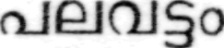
പലവട്ടം
